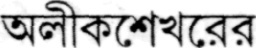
অলীকশেখরের
